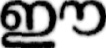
ഈ
